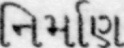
નિર્માણ
